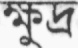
ক্ষুদ্র
